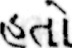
હતો
